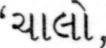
'ચાલો
